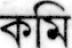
কমি
